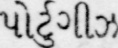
પોર્ટુગીઝ
